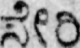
ಸೇರಿ
